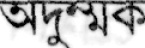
অদুম্মক
